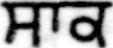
ਸਾਕ
